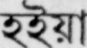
হইয়া
